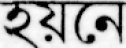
হয়নে
